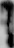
l
